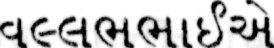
વલ્લભભાઈએ
